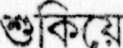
শুকিয়ে
